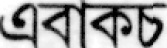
এবাকচ
